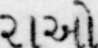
રાઓ
